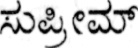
ಸುಪ್ರೀಮ್
